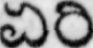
ಏರಿ
